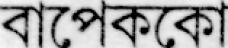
বাপেককো
